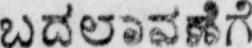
ಬದಲಾವಣೆಗೆ
